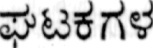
ಘಟಕಗಳ
